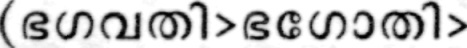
(ഭഗവതി>ഭഗോതി>
